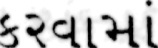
કરવામાં
